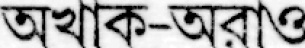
অখাক-অরাও
